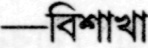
–বিশাখা
